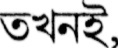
তখনই,
